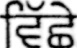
ਵਿੱਛੇ
